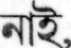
নাই,
